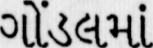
ગોંડલમાં
